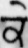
ਕੇ
